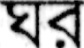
ঘর
